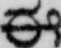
ಈ
